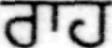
ਰਾਹ
